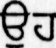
ਉਹ
